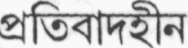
প্রতিবাদহীন
